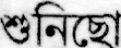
শুনিছো
